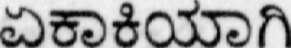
ಏಕಾಕಿಯಾಗಿ
